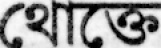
থোক্তে
